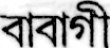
বাবাগী
